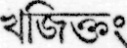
খজিক্তং
